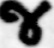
જ
